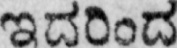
ಇದರಿಂದ
